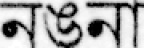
নঙনা
